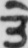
ਤੇ
